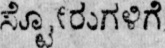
ಸ್ಟೋರುಗಳಿಗೆ
